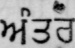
ਅੰਤਰ
